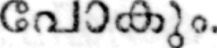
പോകും.
